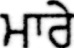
ਮਾਰੇ
